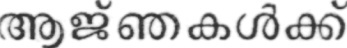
ആജ്ഞകള്‍ക്ക്
